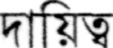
দায়িত্ব
